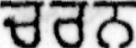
ਚਰਨ
